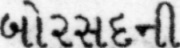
બોરસદની
